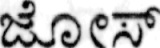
ಜೋಸ್
